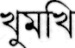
খুমখি
